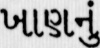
ખાણનું
